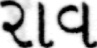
રાવ
